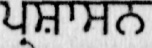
ਪ੍ਰਸ਼ਾਸਨ
